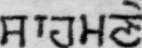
ਸਾਹਮਣੇ
